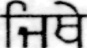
ਜਿਥੇ
